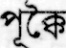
পূক্কৈ
